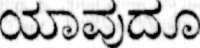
ಯಾವುದೂ
